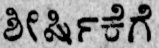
ಶೀರ್ಷಿಕೆಗೆ
